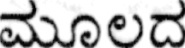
ಮೂಲದ
